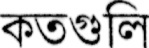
কতগুলি
